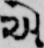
એ
